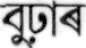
বুঢ়াৰ
